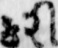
કરી
